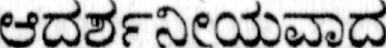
ಆದರ್ಶನೀಯವಾದ
